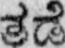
ತಡೆ
